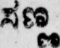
ಸಣ್ಣ
